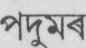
পদুমৰ
